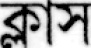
ক্লাস
